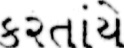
કરતાંયે
